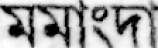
মমাংদা
